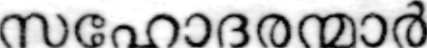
സഹോദരന്മാര്‍
